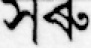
সৰু
